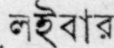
লইবার
